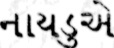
નાયડુએ
